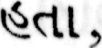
હતા,
